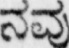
ನವು
